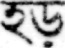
হড়
